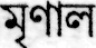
মৃণাল
